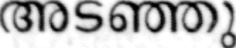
അടഞ്ഞു
